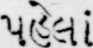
પહેલાં
